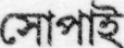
সোপাই
